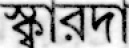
ক্বারদা
